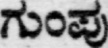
ಗು೦ಪು
